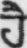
ਹੈ
